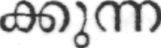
ക്കുന്ന
